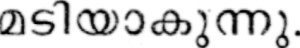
മടിയാകുന്നു.
